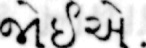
જોઈએ.
